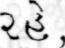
રહે,
